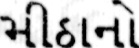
મીઠાનો
